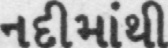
નદીમાંથી
